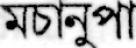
মচানুপা
